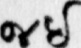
જઈ
